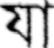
যা
